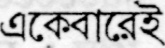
একেবারেই
